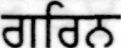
ਗਰਿਨ
